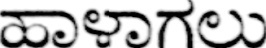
ಹಾಳಾಗಲು
